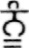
ਨੂੰ
